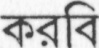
করবি
